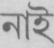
নাই
